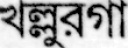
খল্লুরগা
